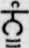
ਨੂੰ
